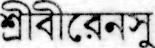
শ্রীবীরেনসু
